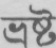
ভ্ৰষ্ট
